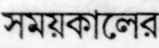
সময়কালের
